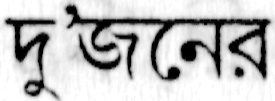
দু'জনের
